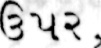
ઉપર,
